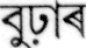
বুঢ়াৰ
